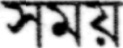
সময়
